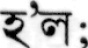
হ'ল;
